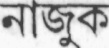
নাজুক
